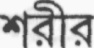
শরীর
